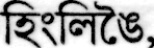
হিংলিঙৈ,
